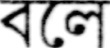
বলে
